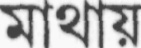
মাথায়
